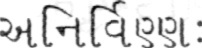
અનિર્વિણ્ણઃ
